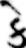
કે
